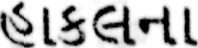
હાકલના
